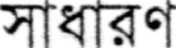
সাধারণ
